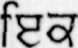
ਇਕ
